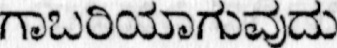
ಗಾಬರಿಯಾಗುವುದು
